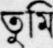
তুমি
